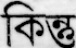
কিন্তু
